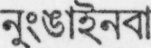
নুংঙাইনবা
